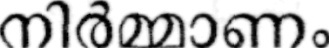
നിര്‍മ്മാണം
